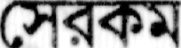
সেরকম
